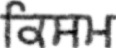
ਕਿਸਮ
